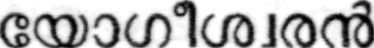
യോഗീശ്വരന്‍
